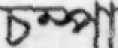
চম্পা
